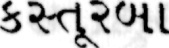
કસ્તૂરબા
